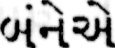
બંનેએ
